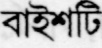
বাইশটি
